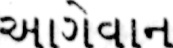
આગેવાન
